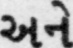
અને
